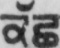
ਕੱਛ
